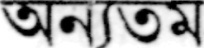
অন্যতম
